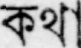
কথা
